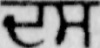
ਦਸ
